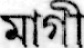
মাগী
